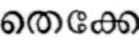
തെക്കേ
